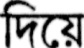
দিয়ে
